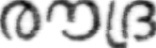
രൌദ്ര
